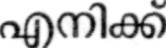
എനിക്ക്
